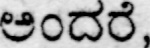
ಅಂದರೆ,
